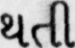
થતી
